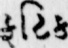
ફટિક
